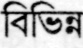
বিভিন্ন
